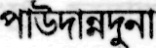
পাউদান্নদুনা
